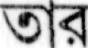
তার
